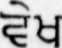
ਵੇਖ
